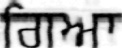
ਗਿਆ
